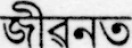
জীৱনত
